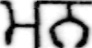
ਮਨ
